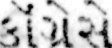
કૉંગ્રેસે
